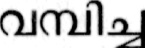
വമ്പിച്ച
